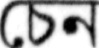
চেন
